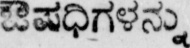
ಔಷಧಿಗಳನ್ನು
